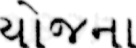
યોજના
